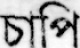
চাপি
